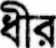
ধীর
